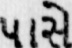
પાસે
